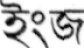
ইংজ
